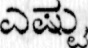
ಎಷ್ಟು
